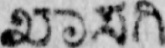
ಖಾಸಗಿ
